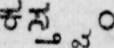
ಕಸ್ತ್ವಂ
